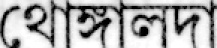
থোঙ্গালদা
